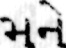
મને
